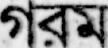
গরম
